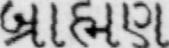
બ્રાહ્મણ
